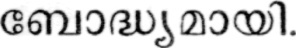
ബോദ്ധ്യമായി.
